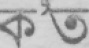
ক'ত
